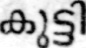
കുട്ടി
